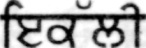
ਇਕੱਲੀ
